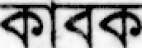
কাবক
